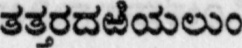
ತತ್ತರದಱಯಲುಂ
